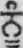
ਨੂੰ
